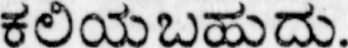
ಕಲಿಯಬಹುದು.
